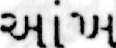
આંખ
